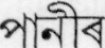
পানীৰ
